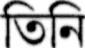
তিনি
